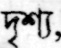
দৃশ্য,
